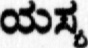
ಯಸ್ಯ
